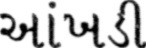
આંખડી
